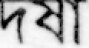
দষা
